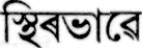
স্থিৰভাৱে
